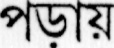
পড়ায়
